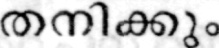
തനിക്കും
